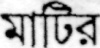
মাটির
